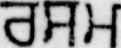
ਰਸਮ
